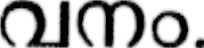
വനം.
